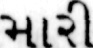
મારી
